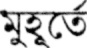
মুহূর্তে
